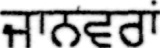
ਜਾਨਵਰਾਂ
